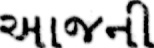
આજની
